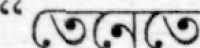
"তেনেতে
